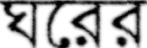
ঘরের
